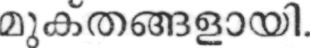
മുക്തങ്ങളായി.
